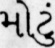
મોટું
